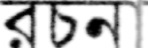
রচনা
